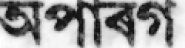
অপাৰগ
